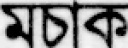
মচাক
